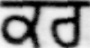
ਕਰ
